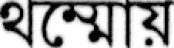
থম্মোয়
